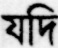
যদি
